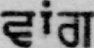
ਵਾਂਗ
